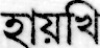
হায়খি
